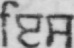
ਇਸ
